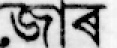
জোৰ
